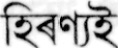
হিৰণ্যই
